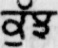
ਕੁੱਝ
